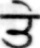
ਤੇ
